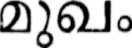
മുഖം
